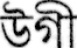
উগী
